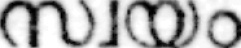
സ്വയം
